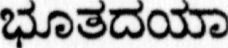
ಭೂತದಯಾ
